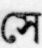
সে
